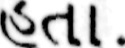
હતા.
